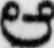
ಆ
